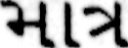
માત્ર
